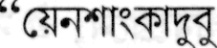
“য়েনশাংকাদুবু
